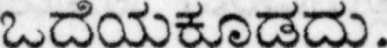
ಒದೆಯಕೂಡದು.
